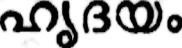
ഹൃദയം
